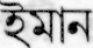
ইমান
